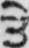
ਤੇ
